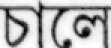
চালে
